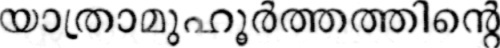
യാത്രാമുഹൂര്‍ത്തത്തിന്റെ
